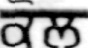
ਕੋਲ
